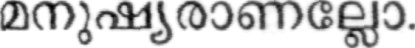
മനുഷ്യരാണല്ലോ.
